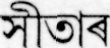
সীতাৰ
